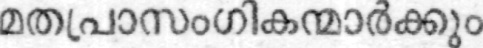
മതപ്രാസംഗികന്മാര്‍ക്കും
